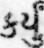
કર્યું
